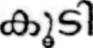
കൂടി
